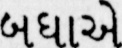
બધાએ
